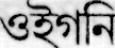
ওইগনি
